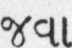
જવા
